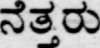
ನೆತ್ತರು
